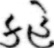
કહે
